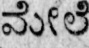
ಮೇಲೆ
